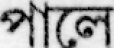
পালে
